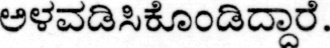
ಅಳವಡಿಸಿಕೊಂಡಿದ್ದಾರೆ.
